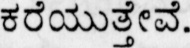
ಕರೆಯುತ್ತೇವೆ.
